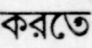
করতে
